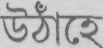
উঠাঁহে
